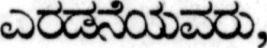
ಎರಡನೆಯವರು,
